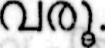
വരൂ.
